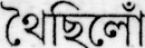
থৈছিলোঁ
